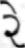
રે
